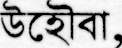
উহৌবা,
